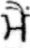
ਮੈਂ
